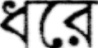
ধরে
